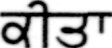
ਕੀਤਾ
